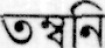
তম্বনি
